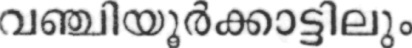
വഞ്ചിയൂര്‍ക്കാട്ടിലും
